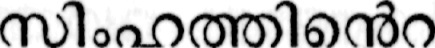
സിംഹത്തിന്റെ
